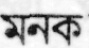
মনক
